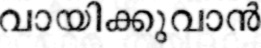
വായിക്കുവാന്‍
